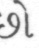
છો
